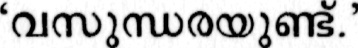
‘വസുന്ധരയുണ്ട്.’
